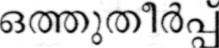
ഒത്തുതീര്‍പ്പ്
